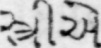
સ્ત્રીએ
